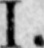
I.
